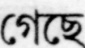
গেছে
